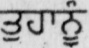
ਤੁਹਾਨੂੰ
